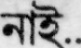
নাই..
